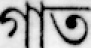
গাত
